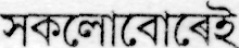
সকলোবোৰেই
